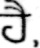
ਹੈ,
